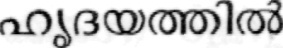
ഹൃദയത്തില്‍
